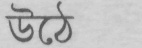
উঠে
